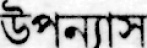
উপন্যাস
